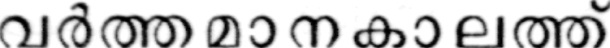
വര്‍ത്തമാനകാലത്ത്
